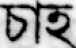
চাহ
